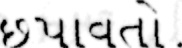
છપાવતો.
